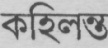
কহিলন্ত
